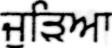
ਜੁੜਿਆ
